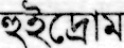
হুইদ্রোম
